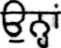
ਉਨ੍ਹਾਂ
